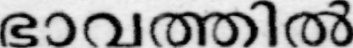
ഭാവത്തില്‍
